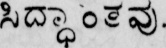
ಸಿದ್ಧಾಂತವು.
